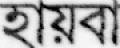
হায়বা
